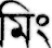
মিং
